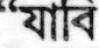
"যাবি
